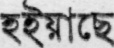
হইয়াছে
